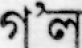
গ'ল
